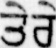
ਤੇਰੇ
